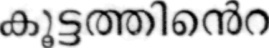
കൂട്ടത്തിന്റെ
